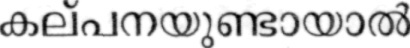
കല്പനയുണ്ടായാല്‍
